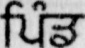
ਪਿੰਡ
